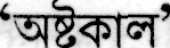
‘অষ্টকাল’
